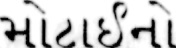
મોટાઈનો
